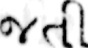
જતી
